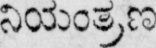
ನಿಯಂತ್ರಣ
